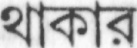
থাকার
